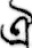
ঐ
